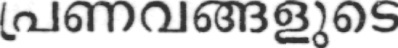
പ്രണവങ്ങളുടെ
